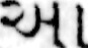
આ
